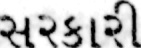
સરકારી
